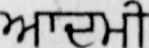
ਆਦਮੀ
